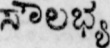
ಸೌಲಭ್ಯ
